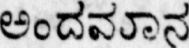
ಅಂದಮಾನ
